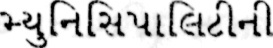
મ્યુનિસિપાલિટીની
